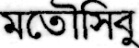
মতৌসিবু
